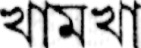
খামখা
